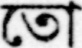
তো
